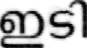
ഇടി
